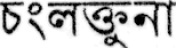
চংলক্তুনা
